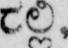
ರಲ್ಲಿ,
